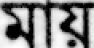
মায়
